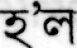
হ'ল
